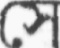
সে
